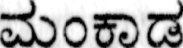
ಮಂಕಾಡ
